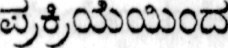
ಪ್ರಕ್ರಿಯೆಯಿಂದ
